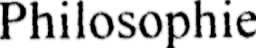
Philosophie
